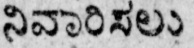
ನಿವಾರಿಸಲು
